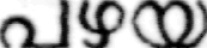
പഴയ
